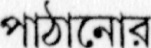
পাঠানোর
